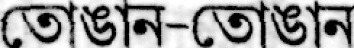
তোঙান-তোঙনা
